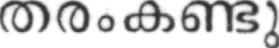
തരംകണ്ടു
